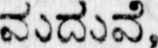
ಮದುವೆ,
